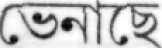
ভেনাছে
